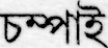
চম্পাই
